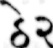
ઠેર
